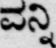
ವನ್ನಿ
